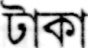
টাকা
